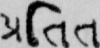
પ્રતિત
